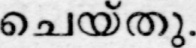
ചെയ്തു.
